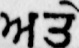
ਅਤੇ
